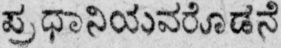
ಪ್ರಧಾನಿಯವರೊಡನೆ
